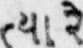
ત્યારે
